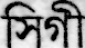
সিগী
